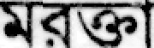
মরক্তা
